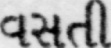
વસતી
